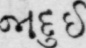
જાદુઈ
